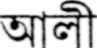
আলী
